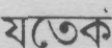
যতেক
